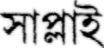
সাপ্লাই
